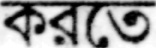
করতে
